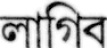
লাগিব
